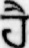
ਹੈ
